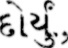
દોર્યું,
